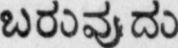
ಬರುವುದು
